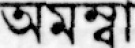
অমম্বা
